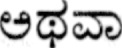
ಅಥವಾ
